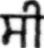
ਸੀ
